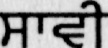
ਸਾਵੀ
